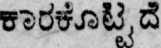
ಕಾರಕೊಟ್ಟಿದೆ
